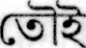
তৌই
